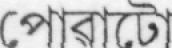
পোৱাটো
